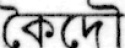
কৈদৌ
